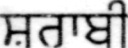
ਸ਼ਰਾਬੀ
